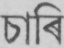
চাৰি
